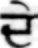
ਦੇ
